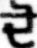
ਦੋ
